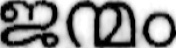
ജന്മം
